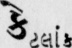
કેટલાંક
